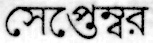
সেপ্তেম্বর
